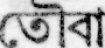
তৌবা
